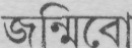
জন্মিবো
